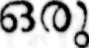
ഒരു
